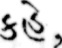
કહે,
